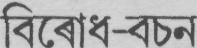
বিৰোধ-বচন
